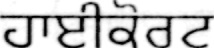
ਹਾਈਕੋਰਟ
